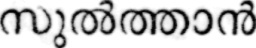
സുല്‍ത്താന്‍
